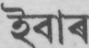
ইবাৰ
